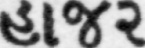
હાજર
